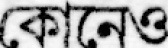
কোনেও
